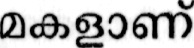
മകളാണ്
